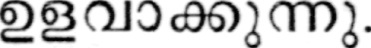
ഉളവാക്കുന്നു.
